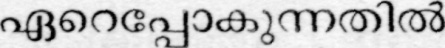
ഏറെപ്പോകുന്നതില്‍
